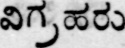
ವಿಗ್ರಹರು
